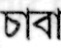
চাবা
